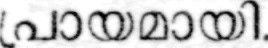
പ്രായമായി.
